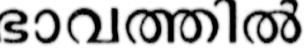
ഭാവത്തില്‍
